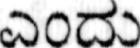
ಎಂದು
